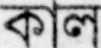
কাল
